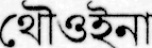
থৌওইনা
